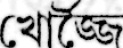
খোর্জ্জৈ
